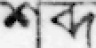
শব্দ
